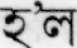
হ'ল
